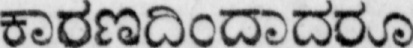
ಕಾರಣದಿಂದಾದರೂ
